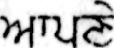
ਆਪਣੇ
